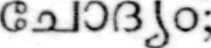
ചോദ്യം;
